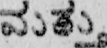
ಮತ್ತು
